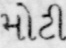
મોટી
